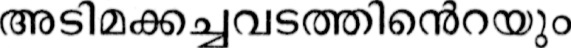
അടിമക്കച്ചവടത്തിന്റെയും
